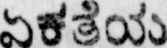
ಏಕತೆಯ
